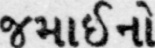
જમાઈનો
